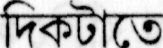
দিকটাতে
